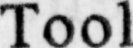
Tool
